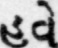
હવે
